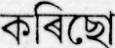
কৰিছো
